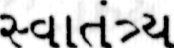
સ્વાતંત્ર્ય
